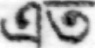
এত
